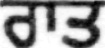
ਰਾਤ
